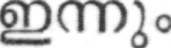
ഇന്നും
